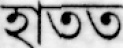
হাতত
